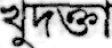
খুদক্তা
